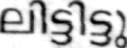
ലിട്ടിട്ടു
